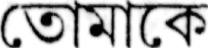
তোমাকে
